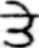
ਤੇ
